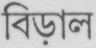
বিড়াল
